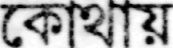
কোথায়
